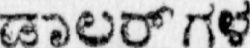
ಡಾಲರ್‌ಗಳ
